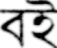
বই
